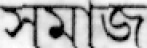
সমাজ
